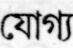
যোগ্য
